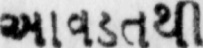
આવડતથી
